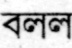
বলল
